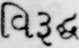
વિરૂદ્ધ
